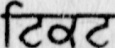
ਟਿਕਟ
